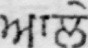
ਆਲੇ
